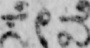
ಸೇವೆ
